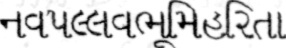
નવપલ્લવભૂમિહરિતા
